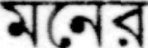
মনের
